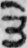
ਤੇ
